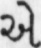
એ
